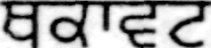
ਥਕਾਵਟ
